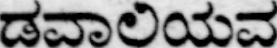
ಡವಾಲಿಯವ
